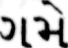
ગમે
